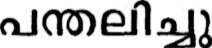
പന്തലിച്ചു
